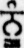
ਨੂੰ
